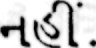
નહીં.
